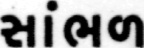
સાંભળ
